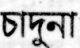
চাদুনা
